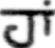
ਹਾਂ
